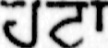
ਹਟਾ
